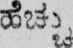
ಹೆಚ್ಚು
